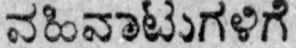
ವಹಿವಾಟುಗಳಿಗೆ
